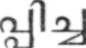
പ്പിച്ച
